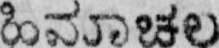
ಹಿಮಾಚಲ
